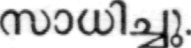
സാധിച്ചു.
